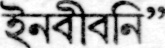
ইনবীবনি”
